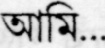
আমি...
